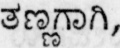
ತಣ್ಣಗಾಗಿ,
